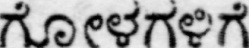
ಗೋಳಗಳಿಗೆ
